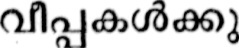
വീപ്പകള്‍ക്കു
